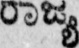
ರಾಜ್ಯ
